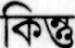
কিন্তু
